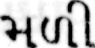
મળી
